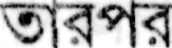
তারপর
